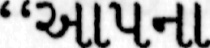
"આપના
